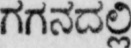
ಗಗನದಲ್ಲಿ
